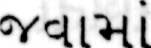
જવામાં
